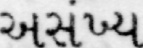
અસંખ્ય
